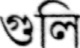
গুলি
